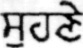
ਸੁਹਣੇ
